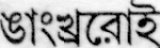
ঙাংখ্ররোই
